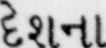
દેશના
